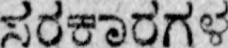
ಸರಕಾರಗಳ
